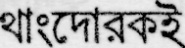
থাংদোরকই
